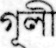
গূলী
